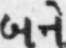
બને
